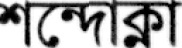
শন্দোক্না
